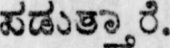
ಪಡುತ್ತಾರೆ.
